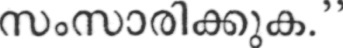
സംസാരിക്കുക."
